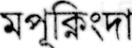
মপূক্নিংদা
